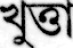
খুত্তা
